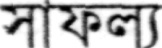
সাফল্য
